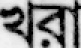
খরা
